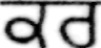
ਕਰ
